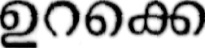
ഉറക്കെ
